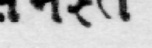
સમસ્ત
